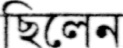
ছিলেন
